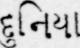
દુનિયા
